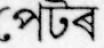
পেটৰ
